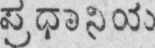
ಪ್ರಧಾನಿಯ
